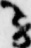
કે
